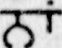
ਨਾਂ
